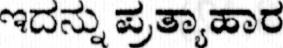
ಇದನ್ನುಪ್ರತ್ಯಾಹಾರ
